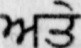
ਅਤੇ
